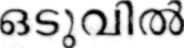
ഒടുവില്‍
